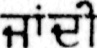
ਜਾਂਦੀ
